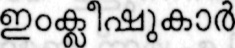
ഇംക്ലീഷുകാര്‍
